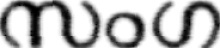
സംഗ
